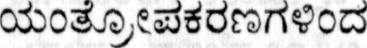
ಯಂತ್ರೋಪಕರಣಗಳಿಂದ
